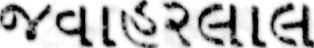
જવાહરલાલ
